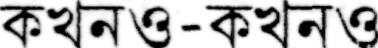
কখনও-কখনও
